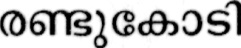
രണ്ടുകോടി
